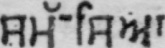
ਸਮੱਸਿਆ
